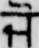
ਜੋ
